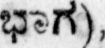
ಭಾಗ),
